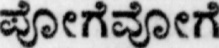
ಪೋಗೆವೋಗೆ
